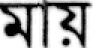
মায়
